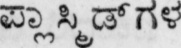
ಪ್ಲಾಸ್ಮಿಡ್‌ಗಳ
